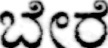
ಬೇರೆ
